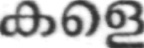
കളെ
